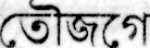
তৌজগে
